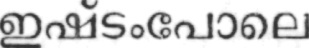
ഇഷ്ടംപോലെ
